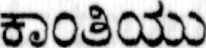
ಕಾಂತಿಯು
